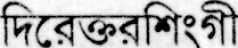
দিরেক্তরশিংগী
